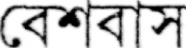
বেশবাস
